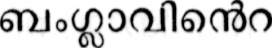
ബംഗ്ലാവിന്റെ
